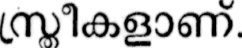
സ്ത്രീകളാണ്.
